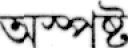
অস্পষ্ট
